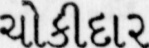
ચોકીદાર
